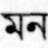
মন
